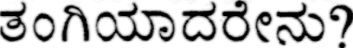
ತಂಗಿಯಾದರೇನು?
